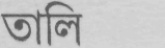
তালি
